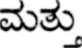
ಮತ್ತು
